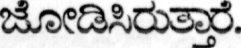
ಜೋಡಿಸಿರುತ್ತಾರೆ.
